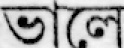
ভালে
